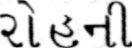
રોહની
